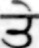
ਤੇ
